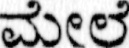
ಮೇಲೆ
